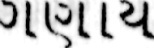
ગણાય
